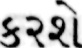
કરશે
